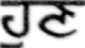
ਹੁਣ
